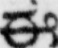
ಈ
